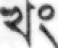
খং
